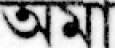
অমা
